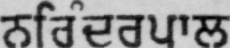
ਨਰਿੰਦਰਪਾਲ
